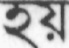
হয়
